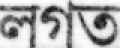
লগত
